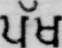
ਪੱਖ
